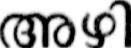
അഴി
